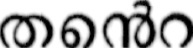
തന്റെ
